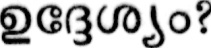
ഉദ്ദേശ്യം?
